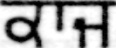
ਕਾਜ
